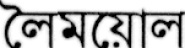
লৈময়োল
